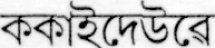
ককাইদেউৱে
